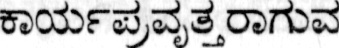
ಕಾರ್ಯಪ್ರವೃತ್ತರಾಗುವ
